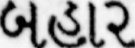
બહાર
